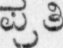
ಪ್ರತಿ
